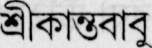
শ্রীকান্তবাবু
